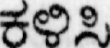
ಕಳಿಸಿ
